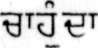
ਚਾਹੁੰਦਾ
